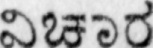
ವಿಚಾರ
